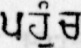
ਪਹੁੰਚ
